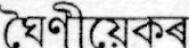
ঘৈণীয়েকৰ
